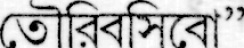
তৌরিবসিবো”
